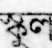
স্কুল
